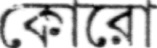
কোরো
